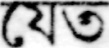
যেত
